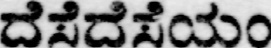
ದೆಸೆದೆಸೆಯಂ
